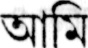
আমি
